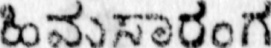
ಹಿಮಸಾರಂಗ
